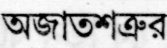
অজাতশত্রুর
